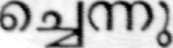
ച്ചെന്നു
